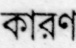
কারণ
